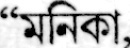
“মনিকা,
